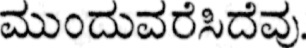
ಮುಂದುವರೆಸಿದೆವು.
